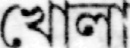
খোলা
